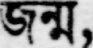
জন্ম,
